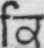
ਕਿ
